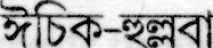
ঈচিক-হুল্লবা
